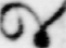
જ
